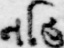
નહિ
